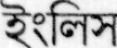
ইংলিস
